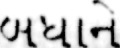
બધાને
